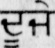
ਦੂਜੇ
